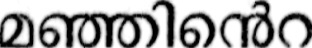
മഞ്ഞിന്റെ
